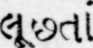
લૂછતાં
